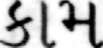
કામ
